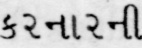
કરનારની
